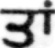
ਤਾਂ
